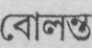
বোলন্ত
